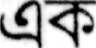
এক
